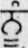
ਨੂੰ
